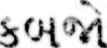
કબજો
